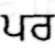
ਪਰ
